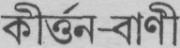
কীৰ্ত্তন-বাণী
